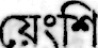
য়েংশি
